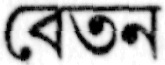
বেতন
